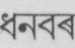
ধনবৰ
